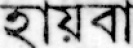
হায়বা
